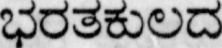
ಭರತಕುಲದ
